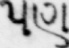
પણ
